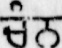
ਚੰਨ
